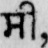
ਸੀ,
